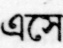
এসে
